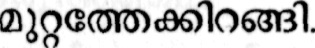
മുറ്റത്തേക്കിറങ്ങി.
